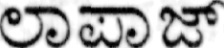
ಲಾಪಾಜ್
